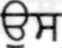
ਉਸ
